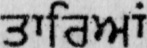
ਤਾਰਿਆਂ
